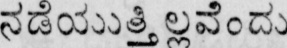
ನಡೆಯುತ್ತಿಲ್ಲವೆಂದು
